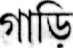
গাড়ি
